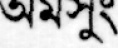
অমসুং
